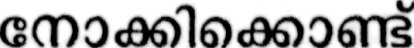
നോക്കിക്കൊണ്ട്
